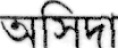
অসিদা
